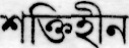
শক্তিহীন
